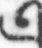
এ
